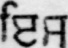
ਇਸ
